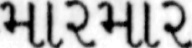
મારમાર
